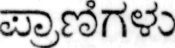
ಪ್ರಾಣಿಗಳು
